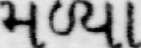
મળ્યા
